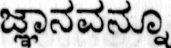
ಜ್ಞಾನವನ್ನೂ
